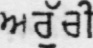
ਅਰੁੱਚੀ
